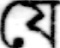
যে
